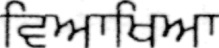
ਵਿਆਖਿਆ
